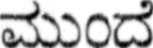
ಮುಂದೆ
